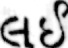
લઈ
